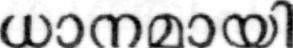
ധാനമായി
